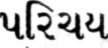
પરિચય
